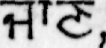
ਜਾਣ,
